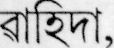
ৱাহিদা,
